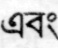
এবং
